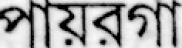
পায়রগা
